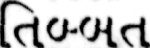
તિબ્બત
